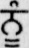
ਨੂੰ
